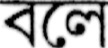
বলে
